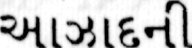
આઝાદની
